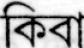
কিবা
